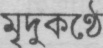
মৃদুকণ্ঠে
